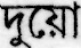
দুয়ো
